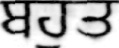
ਬਹੁਤ
